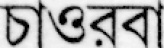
চাওরবা
